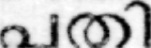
പതി
